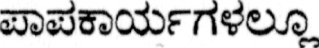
ಪಾಪಕಾರ್ಯಗಳಲ್ಲೂ
